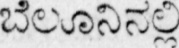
ಬೆಲೂನಿನಲ್ಲಿ
